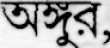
অঙ্গুর,
